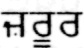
ਜ਼ਰੂਰ
